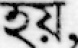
হয়,
